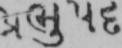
પ્રભુપદ
